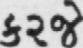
કરજે
